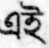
এই
